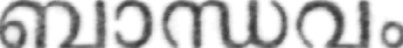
ബാന്ധവം
